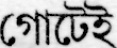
গোটেই
